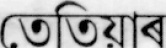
তেতিয়াৰ
